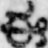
ಈ
